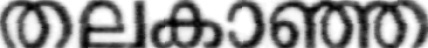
തലകാഞ്ഞ
